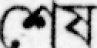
শেষ
